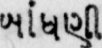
બાંધણી
